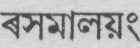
ৰসমালয়ং
